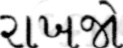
રાખજો
